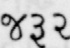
જરૂર
